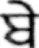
ਬੇ
